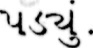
પડ્યું.
